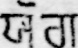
ਯੋਗ
